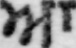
ਆ
